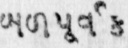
બળપૂર્વક
